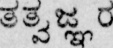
ತತ್ವಜ್ಞರ
